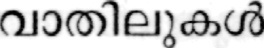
വാതിലുകള്‍
